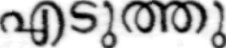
എടുത്തു
